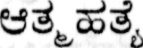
ಆತ್ಮಹತ್ಯೆ
